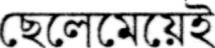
ছেলেমেয়েই
